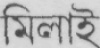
মিলাই
